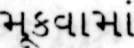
મૂકવામાં
